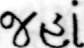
જહાં
